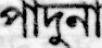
পাদুনা
